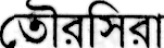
তৌরসিরা
